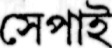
সেপাই
